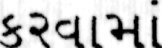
કરવામાં
